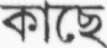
কাছে
